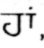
ਹਾਂ,
